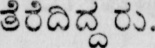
ತೆರೆದಿದ್ದರು.
